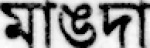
মাঙদা
